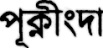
পূক্নীংদা
